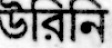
উরিনি
